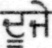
ਦੂਜੇ
